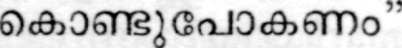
കൊണ്ടുപോകണം”
